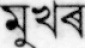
মুখৰ
